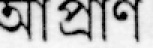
আপ্রাণ
